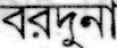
বরদুনা
